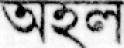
অহল
